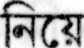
নিয়ে
